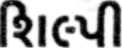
શિલ્પી
